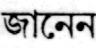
জানেন
